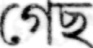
গেছ
